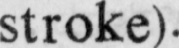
stroke).
